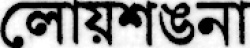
লোয়শঙনা
